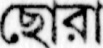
ছোরা
